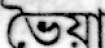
ভৈয়া
